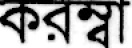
করম্বা
